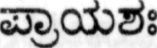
ಪ್ರಾಯಶಃ
